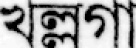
খল্লগা
